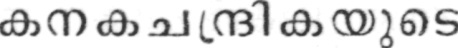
കനകചന്ദ്രികയുടെ
